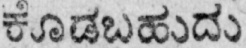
ಕೊಡಬಹುದು
